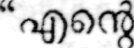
“എന്റെ
